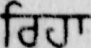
ਰਿਹਾ
